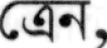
ত্রেন,
